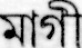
মাগী
